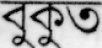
বুকুত
